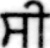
ਸੀ
